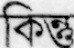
কিন্তু
